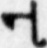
ન
